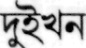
দুইখন
